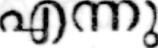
എന്നു
